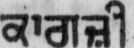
ਕਾਗਜ਼ੀ
